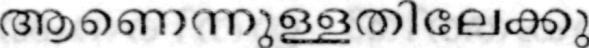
ആണെന്നുള്ളതിലേക്കു
